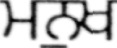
ਮਨੁਖ
